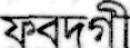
ফবদগী
